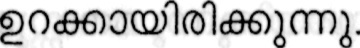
ഉറക്കായിരിക്കുന്നു.
